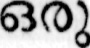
ഒരു
